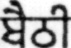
ਬੈਠੀ
